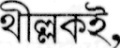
থীল্লকই,
